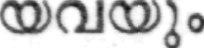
യവയും
